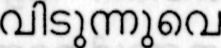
വിടുന്നുവെ
